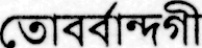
তোর্ব্বান্দগী
